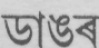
ডাঙৰ
